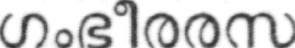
ഗംഭീരരസ
